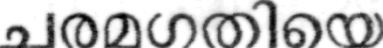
ചരമഗതിയെ
